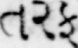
તરફ
